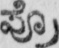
ಪ್ರೊ
